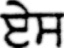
ਏਸ
